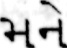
મને
